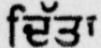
ਦਿੱਤਾ
